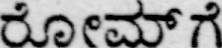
ರೋಮ್‌ಗೆ
